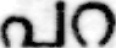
പറ
